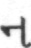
ન
